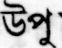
উপু
